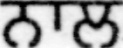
ਨਾਲ
